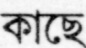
কাছে
